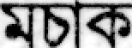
মচাক
